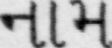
નામ
